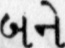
બને
